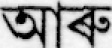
আৰু
